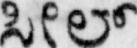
ಸೀಲ್
